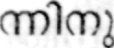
ന്നിനു
